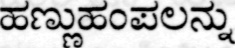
ಹಣ್ಣುಹಂಪಲನ್ನು
